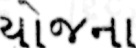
યોજના
